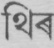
থিৰ
